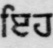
ਇਹ
